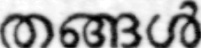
തങ്ങള്‍
